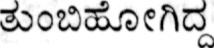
ತುಂಬಿಹೋಗಿದ್ದ
